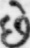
છે
